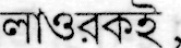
লাওরকই,
